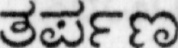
ತರ್ಪಣ
